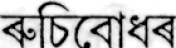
ৰুচিবোধৰ
